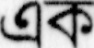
এক
